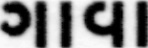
ગાવા
